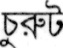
চুরুট
